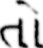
તો
